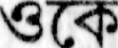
ওকে
